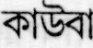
কাউবা
